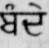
ਬੰਦੇ
